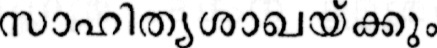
സാഹിത്യശാഖയ്ക്കും
